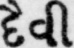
દૈવી
